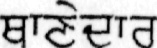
ਥਾਣੇਦਾਰ
